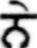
ਨੇ
